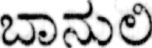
ಬಾನುಲಿ
